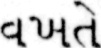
વખતે
